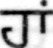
ਹਾਂ
